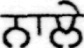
ਨਾਲੇ
